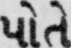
પોતે
